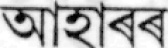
আহাৰৰ
